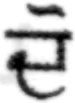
ਦੋ
